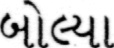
બોલ્યા
